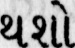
થશો
